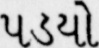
પડયો
